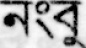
নংবু
